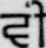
ਵੀ
